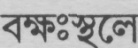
বক্ষঃস্থলে
